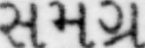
સમગ્ર
